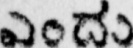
ಎಂದು
